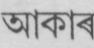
আকাৰ
